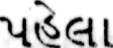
પહેલા
